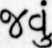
જવું
